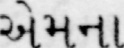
એમના
